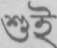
শুই
